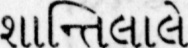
શાન્તિલાલે
